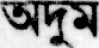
অদুম
